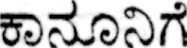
ಕಾನೂನಿಗೆ
